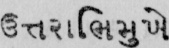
ઉત્તરાભિમુખે
